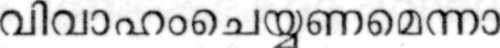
വിവാഹംചെയ്യണമെന്നാ
